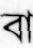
বা
